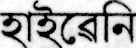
হাইৱেনি
